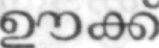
ഊക്ക്
